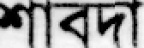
শাবদা
